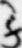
કે
